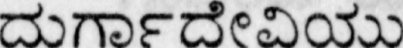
ದುರ್ಗಾದೇವಿಯು
